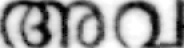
അവ
